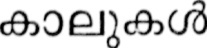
കാലുകള്‍
